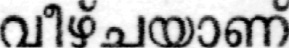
വീഴ്ചയാണ്
